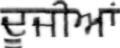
ਦੂਜੀਆਂ
